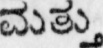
ಮತ್ತು
